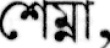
শেম্না,
